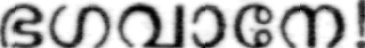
ഭഗവാനേ!
